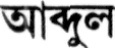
আব্দুল
